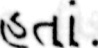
હતાં.
